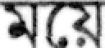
ময়ে
